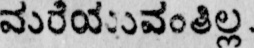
ಮರೆಯುವಂತಿಲ್ಲ.
